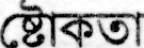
ষ্টোকতা
